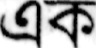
এক
